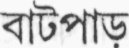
বাটপাড়
